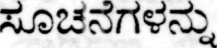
ಸೂಚನೆಗಳನ್ನು
